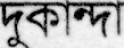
দুকান্দা
